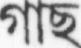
গাছ
